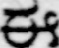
ಈ
